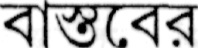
বাস্তবের
